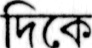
দিকে
